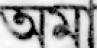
অমা
